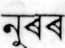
নুৰৰ
